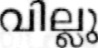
വില്ലു
